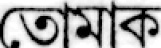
তোমাক
